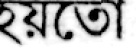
হয়তো
